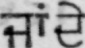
ਜਾਂਦੇ
